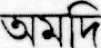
অমদি
